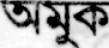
অমুক
